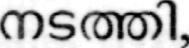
നടത്തി,
